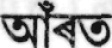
আঁৰত
